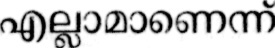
എല്ലാമാണെന്ന്
